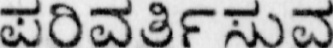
ಪರಿವರ್ತಿಸುವ
